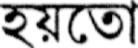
হয়তো
